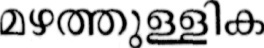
മഴത്തുള്ളിക
